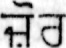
ਜ਼ੋਰ
